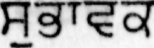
ਸੁਭਾਵਕ
